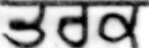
ਤਰਕ
